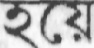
হয়ে
